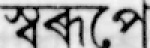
স্বৰূপে
